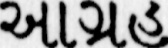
આગ્રહ
